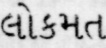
લોકમત
